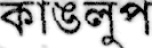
কাঙলুপ
